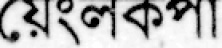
য়েংলকপা
